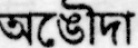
অঙৌদা
